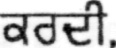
ਕਰਦੀ,
